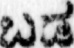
ಬಡ
